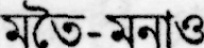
মতৈ-মনাও
